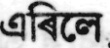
এৰিলে
